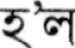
হ'ল
